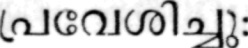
പ്രവേശിച്ചു:
